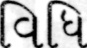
વિધિ
